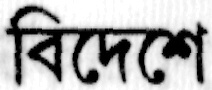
বিদেশে
